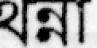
থন্না
